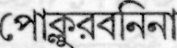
পোক্লুরবনিনা
